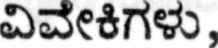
ವಿವೇಕಿಗಳು,
